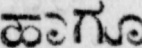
ಹಾಗೂ
